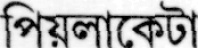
পিয়লাকেটা
